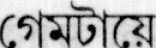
গেমটায়ে
